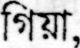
গিয়া,
